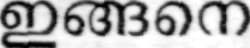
ഇങ്ങനെ
